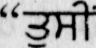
''ਤੁਸੀਂ
